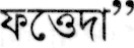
ফত্তে”
